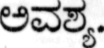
ಅವಶ್ಯ.
